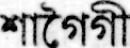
শাগৈসু
